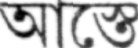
আস্তে
